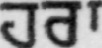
ਹਰਾ
